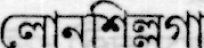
লোনশিল্লগা
